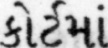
કોર્ટમાં
